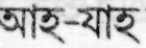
আহ-যাহ
